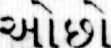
ઓછો
